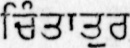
ਚਿੰਤਾਤੁਰ
